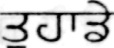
ਤੁਹਾਡੇ
